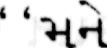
"મને
